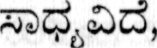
ಸಾಧ್ಯವಿದೆ,
